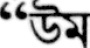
“উম
